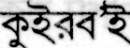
কুইরব’ই
